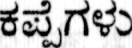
ಕಪ್ಪೆಗಳು
